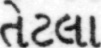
તેટલા
